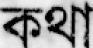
কথা
